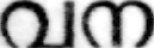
വന
